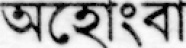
অহোংবা
